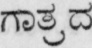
ಗಾತ್ರದ
